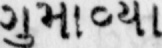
ગુમાવ્યા
